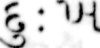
દુઃખ
